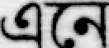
এনে
